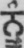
ਨੂੰ
